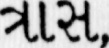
ત્રાસ,
